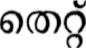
തെറ്റ്
